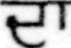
ਦਾ
